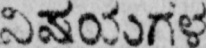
ವಿಷಯಗಳ
